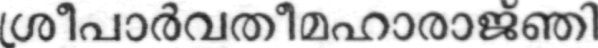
ശ്രീപാര്‍വതീമഹാരാജ്ഞി
